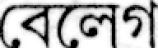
বেলেগ
